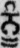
ਨੂੰ
